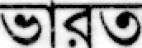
ভারত
